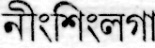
নীংশিংলগা
